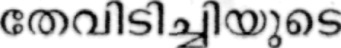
തേവിടിച്ചിയുടെ
